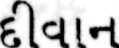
દીવાન
